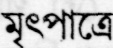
মৃত্পাত্রে
